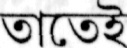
তাতেই
